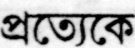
প্রত্যেকে
